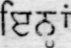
ਇਨ੍ਹਾਂ
